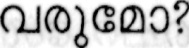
വരുമോ?
